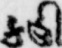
કહી
